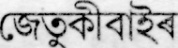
জেতুকীবাইৰ
